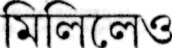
মিলিলেও
